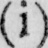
(i)
